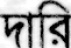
দারি
